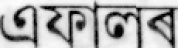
এফালৰ
